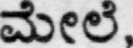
ಮೇಲೆ,
